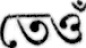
তেওঁ
